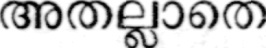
അതല്ലാതെ
